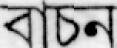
বাচন
